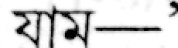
যাম-'
